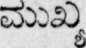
ಮುಖ್ಯ
